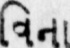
વિના
